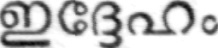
ഇദ്ദേഹം
